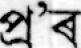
প্র'ৰ
